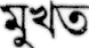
মুখত
